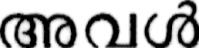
അവള്‍
